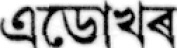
এডোখৰ
